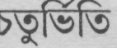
চতুৰ্ভিতি
